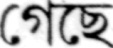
গেছে
